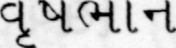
વૃષભાન
